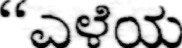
"ಎಳೆಯ
